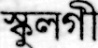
স্কুলগী
